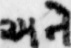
અને
